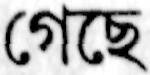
গেছে
